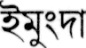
ইমুংদা
